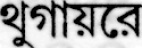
থুগায়রে
